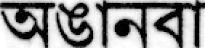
অঙানবা
